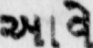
આવે
